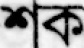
শক
